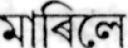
মাৰিলে
